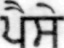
ਪੈਸੇ
